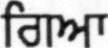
ਗਿਆ
